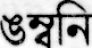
ঙম্বনি
